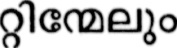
റ്റിന്മേലും
